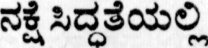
ನಕ್ಷೆಸಿದ್ಧತೆಯಲ್ಲಿ
